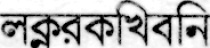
লক্নরকখিবনি
